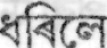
ধৰিলে
